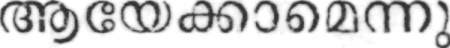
ആയേക്കാമെന്നു
